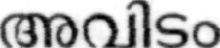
അവിടം
